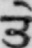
ਤੇ
